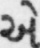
એ
